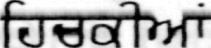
ਹਿਚਕੀਆਂ
